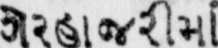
ગેરહાજરીમાં
